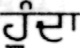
ਹੁੰਦਾ
